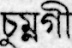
চুম্নগী
